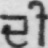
ਦੀ
